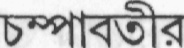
চম্পাবতীর
